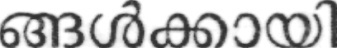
ങ്ങള്‍ക്കായി
